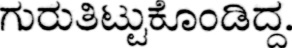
ಗುರುತಿಟ್ಟುಕೊಂಡಿದ್ದ.
